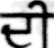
ਦੀ
